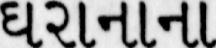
ઘરાનાના
